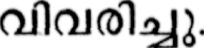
വിവരിച്ചു.
